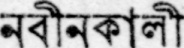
নবীনকালী
